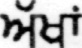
ਅੱਖਾਂ
